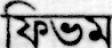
ফিভম
